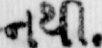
નથી.
